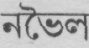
নভৈল
